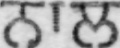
ਨਾਲ
